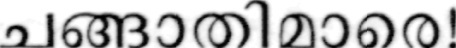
ചങ്ങാതിമാരെ!
